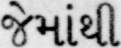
જેમાંથી
